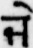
ਜੇ
